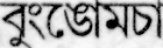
বুংঙোমচা
